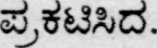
ಪ್ರಕಟಿಸಿದ.
